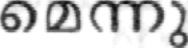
മെന്നു
